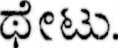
ಥೇಟು.
